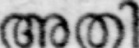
അതി
